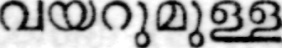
വയറുമുള്ള
